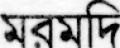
মরমদি
